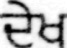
ਦੇਖ
